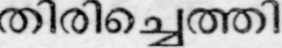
തിരിച്ചെത്തി
